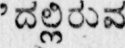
ದಲ್ಲಿರುವ
